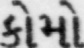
કોમો
